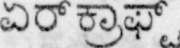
ಏರ್‌ಕ್ರಾಫ್ಟ್
